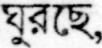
ঘুরছে,
